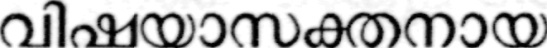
വിഷയാസക്തനായ
